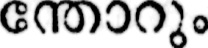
ന്തോറും
